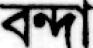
বন্দা
